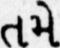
તમે
